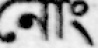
নোং
